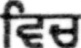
ਵਿਚ
